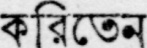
করিতেন
